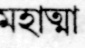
মহাত্মা
